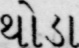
થોડા
